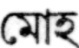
মোহ
